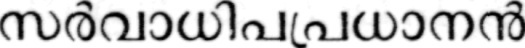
സര്‍വാധിപപ്രധാനന്‍
